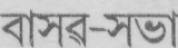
বাসৱ-সভা
